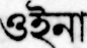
ওইনা
